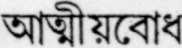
আত্মীয়বোধ
